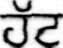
ਹੱਟ
